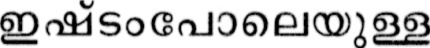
ഇഷ്ടംപോലെയുള്ള
